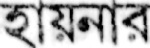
হায়নার
